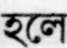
হলে
